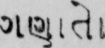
ગણાતો
